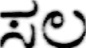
ಸಲ
